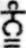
ਨੂੰ
